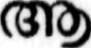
ആ
